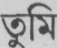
তুমি
